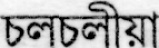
চলচলীয়া
